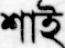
শাই
